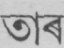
তাৰ
